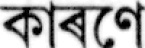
কাৰণে
